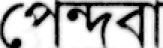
পেন্দবা
